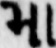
મા
